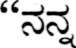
"ನನ್ನ
